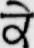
ਕੇ
